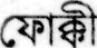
ফোক্কী
